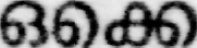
ഒക്കെ
